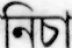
নিচা
